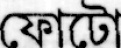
ফোটো
